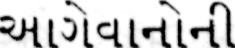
આગેવાનોની
